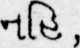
નહિ,
